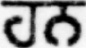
ਹਨ
